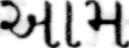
આમ
